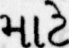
માટે
